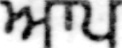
ਆਪ
